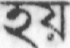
হয়
